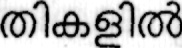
തികളില്‍
